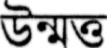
উন্মত্ত
